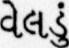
વેલડું
